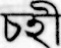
চহী
